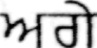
ਅਗੇ
